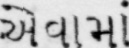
એવામાં
